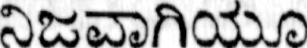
ನಿಜವಾಗಿಯೂ
